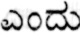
ಎಂದು
